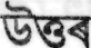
উত্তৰ
